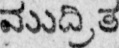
ಮುದ್ರಿತ
